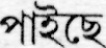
পাইছে
